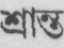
শ্ৰান্ত
